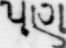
પણ
